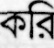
করি
